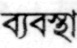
ব্যবস্থা
